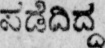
ಪಡೆದಿದ್ದ
